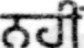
ਨਹੀਂ
